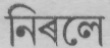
নিৰলে
